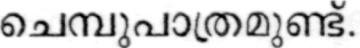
ചെമ്പുപാത്രമുണ്ട്.
